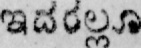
ಇದರಲ್ಲೂ
